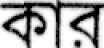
কার
